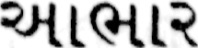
આભાર
